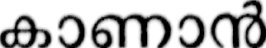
കാണാന്‍
